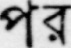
পর
